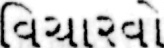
વિચારવો
